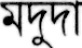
মদুদা
